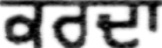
ਕਰਦਾ
